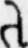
તે
